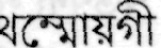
থম্মোয়গী
